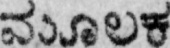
ಮೂಲಕ
